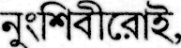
নুংশিবীরোই,
